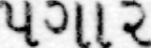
પગાર
